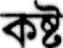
কষ্ট
